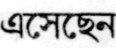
এসেছেন
